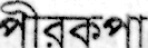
পীরকপা
